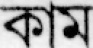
কাম
